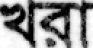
খরা
